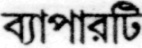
ব্যাপারটি
